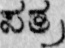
ಪತ್ರ
